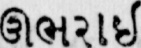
ઊભરાઈ
